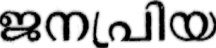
ജനപ്രിയ
